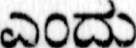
ಎಂದು
